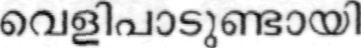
വെളിപാടുണ്ടായി
